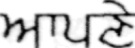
ਆਪਣੇ
